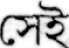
সেই
